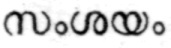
സംശയം
